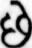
છે
